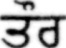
ਤੌਰ
